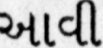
આવી
